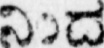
ನಿಂದ
